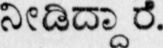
ನೀಡಿದ್ದಾರೆ.
